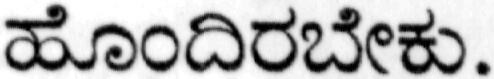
ಹೊಂದಿರಬೇಕು.
